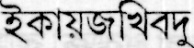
ইকায়জখিবদু
